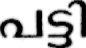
പട്ടി
